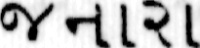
જનારા
